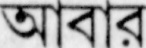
আবার
